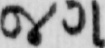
જગ
